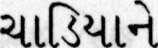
ચાડિયાને
